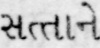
સત્તાને
